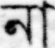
না
